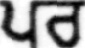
ਪਰ
